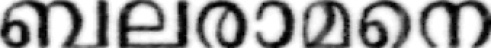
ബലരാമനെ
